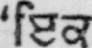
'ਇਕ
